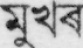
মুখৰ
